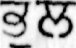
ਭੁਲ
